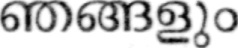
ഞങ്ങളും
